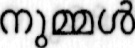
നുമ്മള്‍
